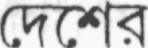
দেশের
